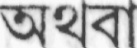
অথবা
